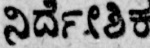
ನಿರ್ದೇಶಿಕ
